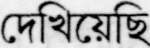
দেখিয়েছি
